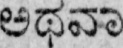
ಅಥವಾ
